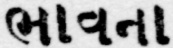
ભાવના
